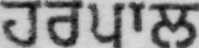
ਹਰਪਾਲ
